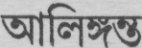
আলিঙ্গন্ত
